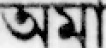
অমা
